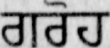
ਗਰੋਹ
